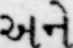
અને
